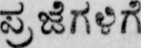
ಪ್ರಜೆಗಳಿಗೆ
